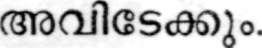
അവിടേക്കും.
